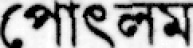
পোৎলম
